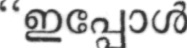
"ഇപ്പോള്‍
